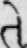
તે
